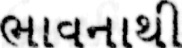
ભાવનાથી
